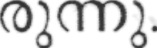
രുന്നു.
